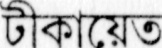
টীকায়েত
